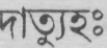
দাত্যুহঃ
